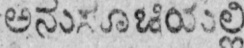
ಅನುಸೂಚಿಯಲ್ಲಿ
